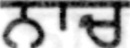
ਨਾਚ
